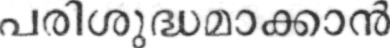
പരിശുദ്ധമാക്കാന്‍
